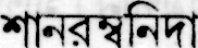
শানরম্বনিদা
